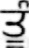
ਤੂੰ
